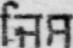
ਜਿਸ
